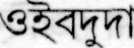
ওইবদুদা
